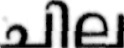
ചില
